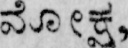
ಮೋಕ್ಷ,
